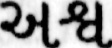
અશ્વ
